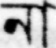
না
